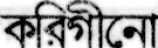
করিগীনো
